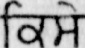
ਕਿਸੇ
